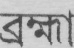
ব্ৰহ্মা
